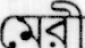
মেরী
